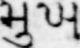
મુખ
